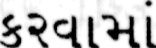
કરવામાં
